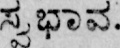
ಸ್ವಭಾವ.
